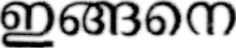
ഇങ്ങനെ
